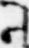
ને
